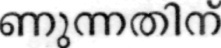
ണുന്നതിന്
